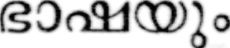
ഭാഷയും
